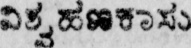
ವಿಶ್ವಹಣಕಾಸು
